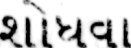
શોધવા
